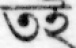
তই
